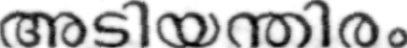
അടിയന്തിരം
